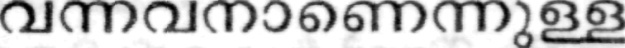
വന്നവനാണെന്നുള്ള
